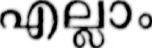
എല്ലാം
